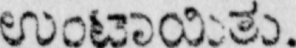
ಉಂಟಾಯಿತು.
